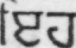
ਇਹ
